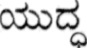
ಯುದ್ಧ
